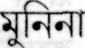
মুনিনা
